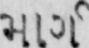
માર્ગ
